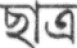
ছাত্ৰ
